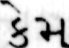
કેમ
